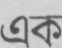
এক
